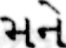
મને
